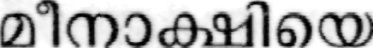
മീനാക്ഷിയെ
